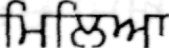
ਮਿਲਿਆ
